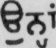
ਉਨ੍ਹਾਂ
